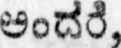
ಅಂದರೆ,
